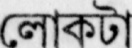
লোকটা
